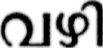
വഴി
